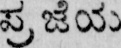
ಪ್ರಜೆಯ
